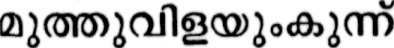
മുത്തുവിളയുംകുന്ന്
